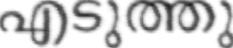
എടുത്തു
